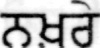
ਨਖ਼ਰੇ
